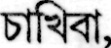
চাখিবা,
